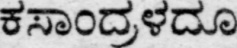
ಕಸಾಂದ್ರಳದೂ
